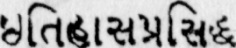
ઈતિહાસપ્રસિદ્ધ
